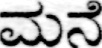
ಮನೆ
